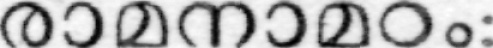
രാമനാമഠം:
